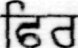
ਫਿਰ
